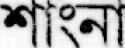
শাংনা
